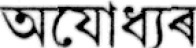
অযোধ্যৰ
